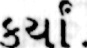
કર્યાં.
